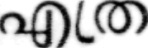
എത്ര
